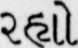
રહ્યો
